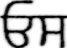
ਓਸ
